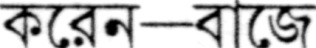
করেন–বাজে
